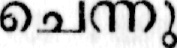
ചെന്നു
